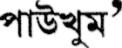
পাউখুম’
